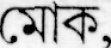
মোক,
